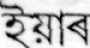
ইয়াৰ
